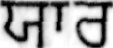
ਯਾਰ
